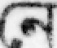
নে
